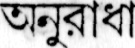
অনুরাধা
